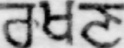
ਰਖਣ
